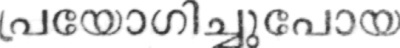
പ്രയോഗിച്ചുപോയ
